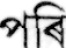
পৰি
